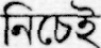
নিচেই
